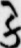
કે
